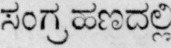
ಸಂಗ್ರಹಣದಲ್ಲಿ
